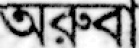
অরুবা
